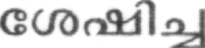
ശേഷിച്ച
